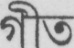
গীত
